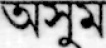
অসুম
